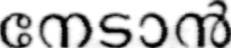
നേടാന്‍
